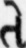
તે
